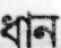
ধান
